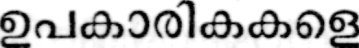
ഉപകാരികകളെ
